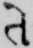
તે
